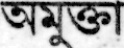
অমুক্তা
